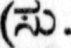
(ಸು.
